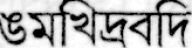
ঙমখিদ্রবদি
